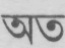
অত
